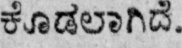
ಕೊಡಲಾಗಿದೆ.
